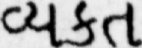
વ્યકત
